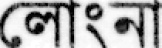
লোংনা
